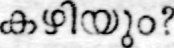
കഴിയും?
